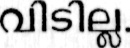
വിടില്ല.
